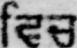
ਵਿਚ
